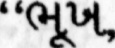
"ભૂખ,
